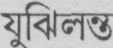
যুঝিলন্ত
